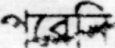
পরেনি
